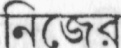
নিজের
